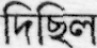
দিছিল
